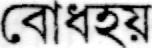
বোধহয়
